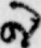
જે
